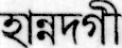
হান্নদগী
